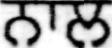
ਨਾਲ
